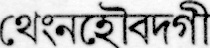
থেংনহৌবদগী
